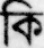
কি
